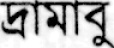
দ্রামাসু
